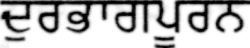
ਦੁਰਭਾਗਪੂਰਨ
